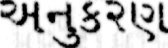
અનુકરણ
